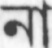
না
